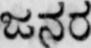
ಜನರ
